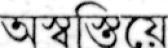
অস্বস্তিয়ে
